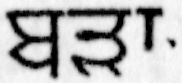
ਬੜਾ
